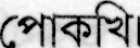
পোকখি।
